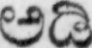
ಅಡಿ
